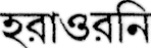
হরাওরনি
